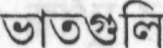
ভাতগুলি
